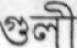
গুলী
